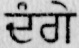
ਦੰਗੇ
